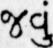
જવું
